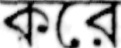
করে
